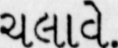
ચલાવે.
